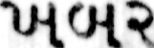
ખબર
